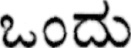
ಒಂದು
